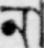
না
